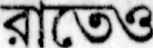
রাতেও
